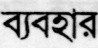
ব্যবহার
